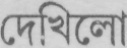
দেখিলো
